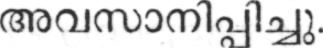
അവസാനിപ്പിച്ചു.
